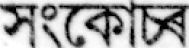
সংকোচৰ
